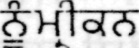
ਨੂੰਮ੍ਰੀਕਨ
